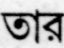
তার
